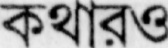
কথারও
